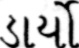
ડાર્યો
